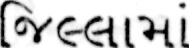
જિલ્લામાં
